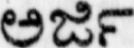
ಅರ್ಜಿ
